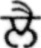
ਲੈ
